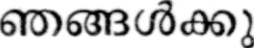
ഞങ്ങള്‍ക്കു
